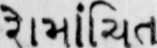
રોમાંચિત
